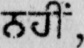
ਨਹੀਂ,
